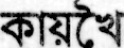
কায়খৈ
